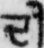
ਦੀ
